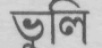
ভুলি
